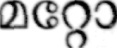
മറ്റോ
